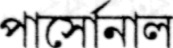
পার্সোনাল
